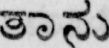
ತಾನು
